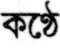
কণ্ঠে
